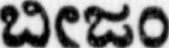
ಬೀಜಂ
